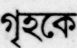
গৃহকে
